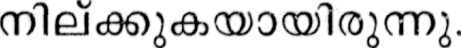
നില്ക്കുകയായിരുന്നു.
